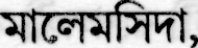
মালেমসিদা,
